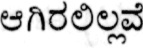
ಆಗಿರಲಿಲ್ಲವೆ
